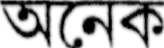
অনেক
